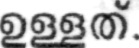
ഉള്ളത്.
